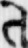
તે
